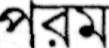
পরম
